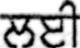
ਲਈ
